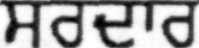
ਸਰਦਾਰ
